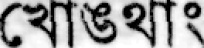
খোঙথাং
